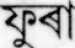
ফুৰা
